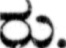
ರು.
